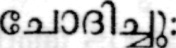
ചോദിച്ചു:
